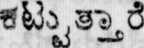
ಕಟ್ಟುತ್ತಾರೆ
